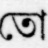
তো
